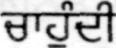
ਚਾਹੁੰਦੀ
